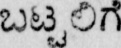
ಬಟ್ಟಲಿಗೆ
